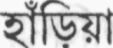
হাঁড়িয়া
